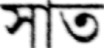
সাত
